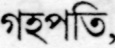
গহপতি,
